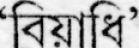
'বিয়াধি'
